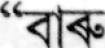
"বাৰু
